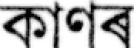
কাণৰ
